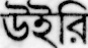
উইরি
